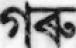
গৰু
